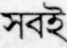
সবই
